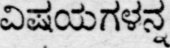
ವಿಷಯಗಳನ್ನ
